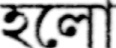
হলো
